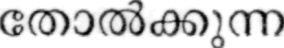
തോല്‍ക്കുന്ന
